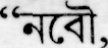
"নবৌ,
